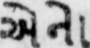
એનો
